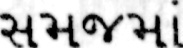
સમજમાં
